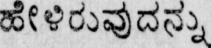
ಹೇಳಿರುವುದನ್ನು
